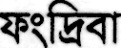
ফংদ্রিবা
